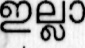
ഇല്ലാ
